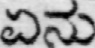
ಏನು
